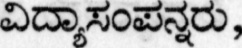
ವಿದ್ಯಾಸಂಪನ್ನರು,
